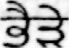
ਭੈੜੇ
